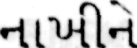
નાખીને
